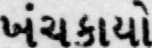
ખંચકાયો
